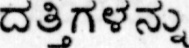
ದತ್ತಿಗಳನ್ನು
